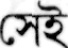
সেই
